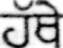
ਹੱਥੇ
